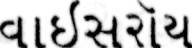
વાઇસરૉય
